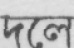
দলে
